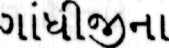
ગાંધીજીના
